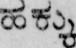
ಹಕ್ಕು
